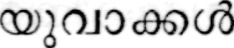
യുവാക്കള്‍
